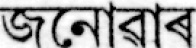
জনোৱাৰ
